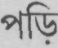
পড়ি
